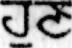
ਹੁਣ
